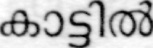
കാട്ടില്‍
